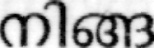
നിങ്ങ
